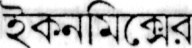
ইকনমিক্সের
